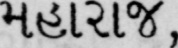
મહારાજ,
